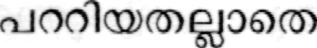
പററിയതല്ലാതെ
